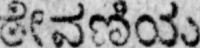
ಠೇವಣಿಯ
